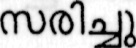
സരിച്ചു
